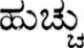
ಹುಚ್ಚು
